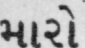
મારો
